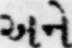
અને
